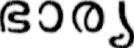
ഭാര്യ
